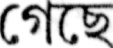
গেছে
